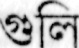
গুলি
